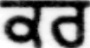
ਕਰ
